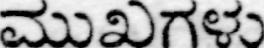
ಮುಖಗಳು
